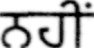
ਨਹੀਂ
